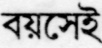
বয়সেই
